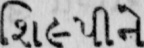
શિલ્પીને
